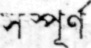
সম্পূর্ণ
